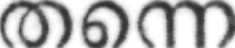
തന്നെ
